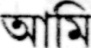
আমি
